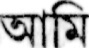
আমি
